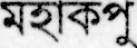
মহাকপু
